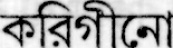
করিগীনো
